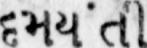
દમયંતી
